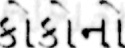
કોકોનો
